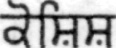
ਕੋਸ਼ਿਸ਼
